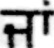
ਜਾਂ
